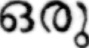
ഒരു
